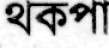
থকপা
